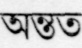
অন্তত
